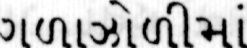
ગળાઝોળીમાં
